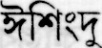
ঈশিংদু
